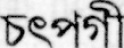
চৎপগী
